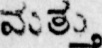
ಮತ್ತು
